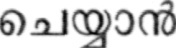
ചെയ്യാന്‍
